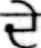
ਦੇ
